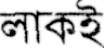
লাকই
